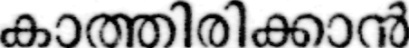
കാത്തിരിക്കാന്‍
